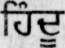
ਹਿੰਦੂ
